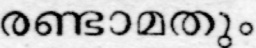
രണ്ടാമതും
